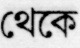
থেকে
